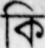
কি
